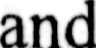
and
